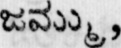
ಜಮ್ಮು,
